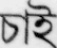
চাই
